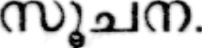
സൂചന.
